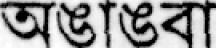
অঙাঙবা
